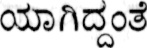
ಯಾಗಿದ್ದಂತೆ
